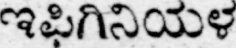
ಇಫಿಗಿನಿಯಳ
